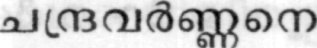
ചന്ദ്രവര്‍ണ്ണനെ
